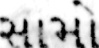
સામો
